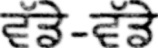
ਵੱਡੇ-ਵੱਡੇ
